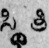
ಸ್ಥಿತಿ
